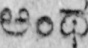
ಅಂಥ
